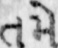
તમે
